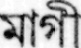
মাগী
